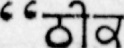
''ਠੀਕ
